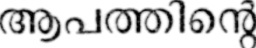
ആപത്തിന്റെ
